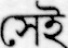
সেই
